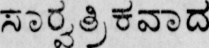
ಸಾರ್ವತ್ರಿಕವಾದ
